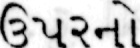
ઉપરનો
